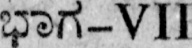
ಭಾಗ-VII
